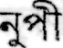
নুপী
